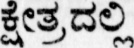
ಕ್ಷೇತ್ರದಲ್ಲಿ
